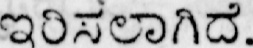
ಇರಿಸಲಾಗಿದೆ.
